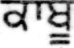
ਕਾਬੂ
